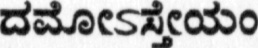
ದಮೋsಸ್ತೇಯಂ
